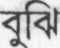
বুঝি
